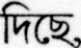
দিছে,
